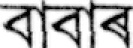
বাবাৰ
